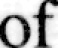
of
